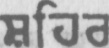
ਸ਼ਹਿਰ
